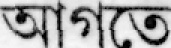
আগতে
